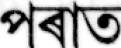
পৰাত
